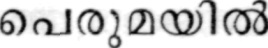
പെരുമയില്‍
